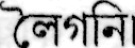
লৈগনি।
